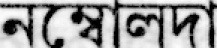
নম্বোলদা
